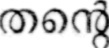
തന്റെ
